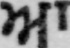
ਆ
